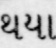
થયા
